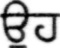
ਉਹ
